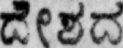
ದೇಶದ
